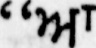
''ਆ
